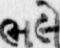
ભલે
